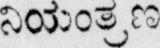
ನಿಯಂತ್ರಣ
